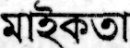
মাইকতা
